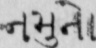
નમુનો
